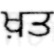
ਖ਼ਤ
